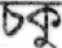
চকু
